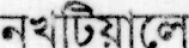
নখটিয়ালে
